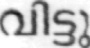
വിട്ടു
